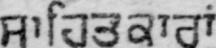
ਸਾਹਿਤਕਾਰਾਂ
